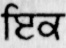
ਇਕ
